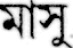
মাসু
